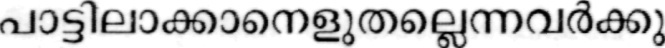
പാട്ടിലാക്കാനെളുതല്ലെന്നവര്‍ക്കു
